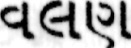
વલણ
